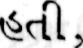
હતી,
